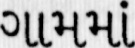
ગામમાં
